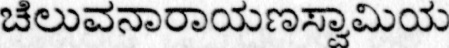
ಚೆಲುವನಾರಾಯಣಸ್ವಾಮಿಯ
